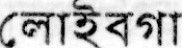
লোইবগা
